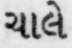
ચાલે
